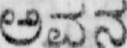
ಅವನ
